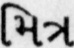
મિત્ર
